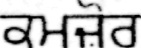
ਕਮਜ਼ੋਰ
